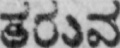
ತರುವ
